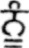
ਨੂੰ
